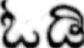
ಓಡಿ
